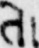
તો
